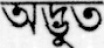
অদ্ভুত
